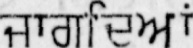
ਜਾਗਦਿਆਂ
